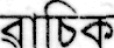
ৱাচিক
